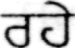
ਰਹੇ
